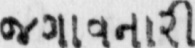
જગાવનારી
